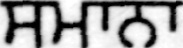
ਸਮਾਨਾ
